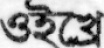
ওইখ্রে
